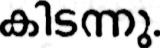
കിടന്നു.
